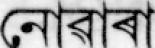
নোৱাৰা
